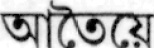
আতৈয়ে
